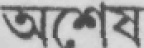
অশেষ
